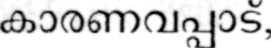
കാരണവപ്പാട്,
